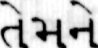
તેમને
